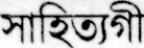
সাহিত্যগী
